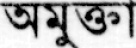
অমুক্তা
